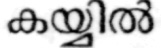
കയ്യില്‍
